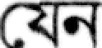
যেন
